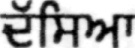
ਦੱਸਿਆ
